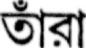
তাঁরা
